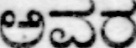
ಅವರ
